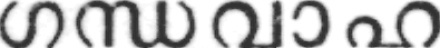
ഗന്ധവാഹ
